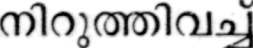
നിറുത്തിവച്ച്
